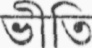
ভীতি
